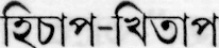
হিচাপ-খিতাপ
